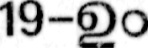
19-ഉം
